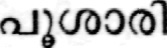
പൂശാരി
